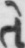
તે
